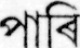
পাৰি
